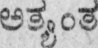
ಅತ್ಯಂತ
